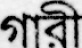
গারী
